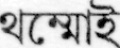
থম্মোই
